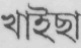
খাইছা
